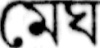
মেঘ
